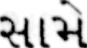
સામે
